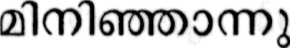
മിനിഞ്ഞാന്നു
